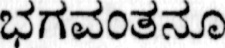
ಭಗವಂತನೂ
